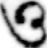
ও
